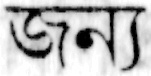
জন্য
